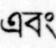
এবং
